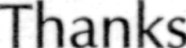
Thanks
